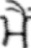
ਮੈਂ
